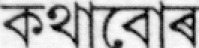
কথাবোৰ
